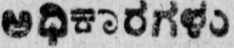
ಅಧಿಕಾರಗಳು
